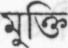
মুক্তি
